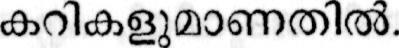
കറികളുമാണതില്‍.
